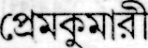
প্রেমকুমারী
